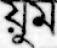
য়ুম
